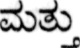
ಮತ್ತು
